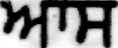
ਆਸ
